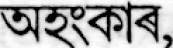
অহংকাৰ,
